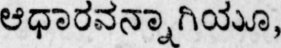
ಆಧಾರವನ್ನಾಗಿಯೂ,
